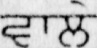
ਵਾਲੇ
